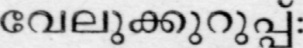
വേലുക്കുറുപ്പ്:
